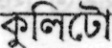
কুলিটো
